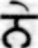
ਨੇ
